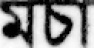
মচা
